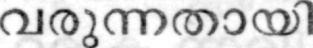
വരുന്നതായി
